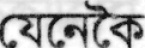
যেনেকৈ
